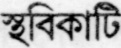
স্থবিকাটি
